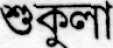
শুকুলা
